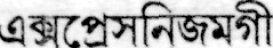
এক্সপ্রেসনিজমগী
